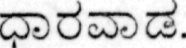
ಧಾರವಾಡ.
